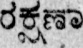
ರಕ್ಷಣಾ
